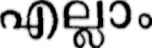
എല്ലാം
